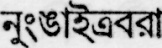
নুংঙাইত্রবরা
